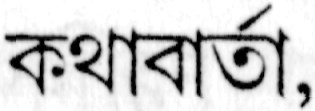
কথাবার্তা,
